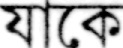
যাকে
